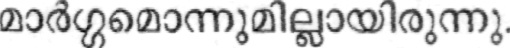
മാര്‍ഗ്ഗമൊന്നുമില്ലായിരുന്നു.
